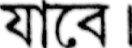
যাবে।
